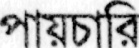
পায়চারি
